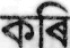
কৰি
